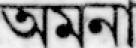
অমনা
